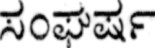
ಸಂಘರ್ಷ
